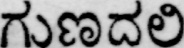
ಗುಣದಲಿ
